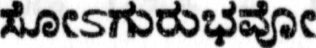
ಸೋsಗುರುಭವೋ
